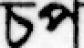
চপ
